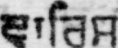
ਵਾਰਿਸ
